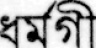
ধর্মগী
